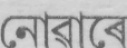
নোৱাৰে
